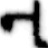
ન
